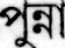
পুন্না
